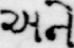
અને
